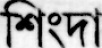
শিংদা
